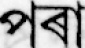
পৰা
